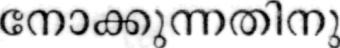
നോക്കുന്നതിനു
